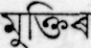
মুক্তিৰ
